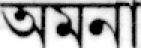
অমনা
